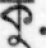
কু.
